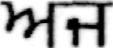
ਅਜ
